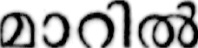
മാറില്‍
